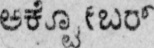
ಅಕ್ಟೋಬರ್
